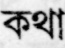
কথা
